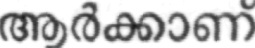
ആര്‍ക്കാണ്
